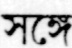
সঙ্গে
